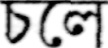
চলে
